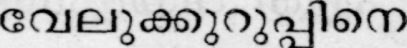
വേലുക്കുറുപ്പിനെ
